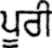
ਪੂਰੀ
